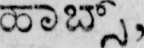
ಹಾಬ್ಸ್,
